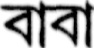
বাবা
